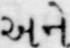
અને
